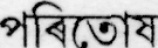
পৰিতোষ
